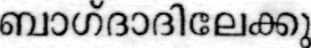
ബാഗ്ദാദിലേക്കു
